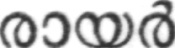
രായര്‍
